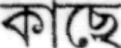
কাছে
